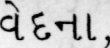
વેદના,
